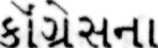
કૉંગ્રેસના
